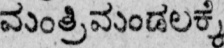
ಮಂತ್ರಿಮಂಡಲಕ್ಕೆ
